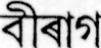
বীৰাগ
